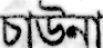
চাউনা
